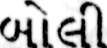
બોલી
